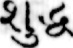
શુદ્ધ
